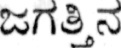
ಜಗತ್ತಿನ
